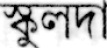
স্কুলদা
